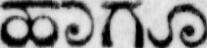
ಹಾಗೂ
